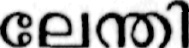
ലേന്തി
